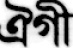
ঐগী
